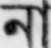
না
